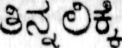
ತಿನ್ನಲಿಕ್ಕೆ
